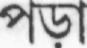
পড়া
